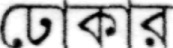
ঢোকার
